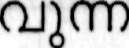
വുന്ന
